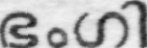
ഭംഗി
